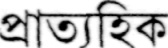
প্রাত্যহিক
